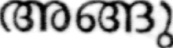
അങ്ങു
